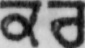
ਕਰ
